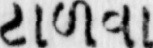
ટાળવા
